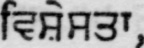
ਵਿਸ਼ੇਸਤਾ,
